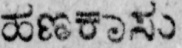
ಹಣಕಾಸು
